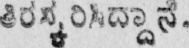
ತಿರಸ್ಕರಿಸಿದ್ದಾನೆ.
